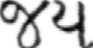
જય
